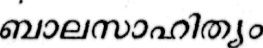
ബാലസാഹിത്യം
